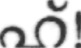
ഹ്!
